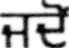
ਜਦੋਂ
